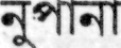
নুপানা
